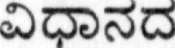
ವಿಧಾನದ
